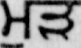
ਮੁੜ
